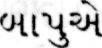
બાપુએ
